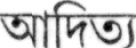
আদিত্য
